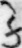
કે
